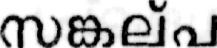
സങ്കല്പ
